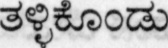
ತಳ್ಳಿಕೊಂಡು
